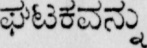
ಘಟಕವನ್ನು
